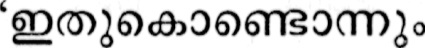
‘ഇതുകൊണ്ടൊന്നും
